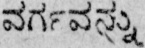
ವರ್ಗವನ್ನು
